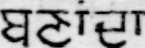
ਬਣਾਂਦਾ
